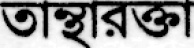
তান্থারক্তা
